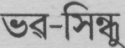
ভৱ-সিন্ধু
